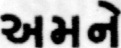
અમને
